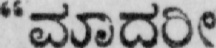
“ಮಾದರೀ
